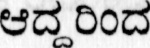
ಆದ್ದರಿಂದ
